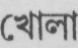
খোলা
